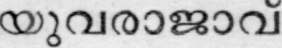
യുവരാജാവ്
